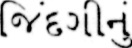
જિંદગીનું
